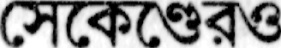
সেকেণ্ডেরও
